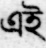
এই
